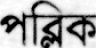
পব্লিক
